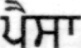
ਪੈਸਾ
